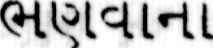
ભણવાના
